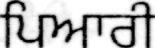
ਪਿਆਰੀ
